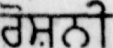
ਰੋਸ਼ਨੀ
